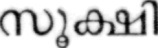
സൂക്ഷി
